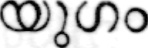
യുഗം
